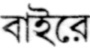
বাইরে
